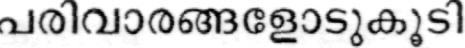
പരിവാരങ്ങളോടുകൂടി
